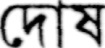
দোষ
